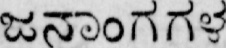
ಜನಾಂಗಗಳ
